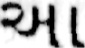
આ
